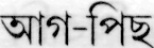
আগ-পিছ
